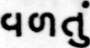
વળતું
